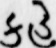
કહે
